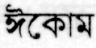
ঈকোম
